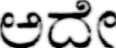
ಅದೇ
